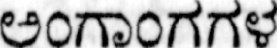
ಅಂಗಾಂಗಗಳ
